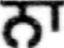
ਨਾ
